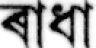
ৰাধা
